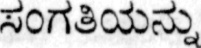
ಸಂಗತಿಯನ್ನು
